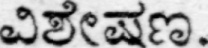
ವಿಶೇಷಣ.
